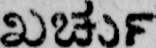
ಖರ್ಚು
